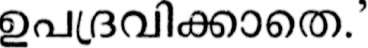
ഉപദ്രവിക്കാതെ.’
